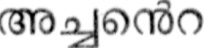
അച്ചന്റെ
